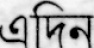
এদিন
